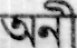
অনী
